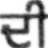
ਦੀ
